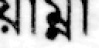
য়াম্না
